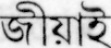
জীয়াই
